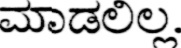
ಮಾಡಲಿಲ್ಲ.
